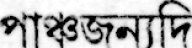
পাঞ্চজন্যদি
